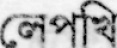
লেপখি
